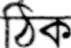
ঠিক
